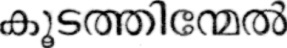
കൂടത്തിന്മേല്‍
